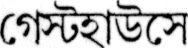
গেস্টহাউসে
